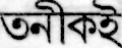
তনীকই
